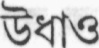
উধাও
